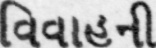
વિવાહની
